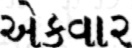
એકવાર
